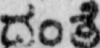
ದಂತೆ
